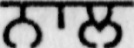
ਨਾਲ
